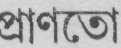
প্ৰাণতো
